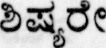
ಶಿಷ್ಯರೇ
